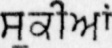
ਸੁਕੀਆਂ
